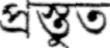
প্রস্তুত
